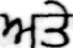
ਅਤੇ
